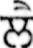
ਲੈ
